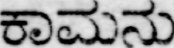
ಕಾಮನು
